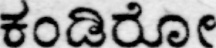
ಕಂಡಿರೋ
